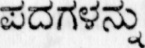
ಪದಗಳನ್ನು
